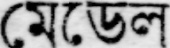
মেডেল
